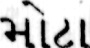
મોટા
